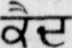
ਕੈਦ
